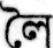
লৈ
